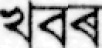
খবৰ
